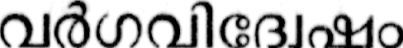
വര്‍ഗവിദ്വേഷം
